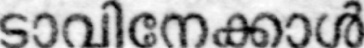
ടാവിനേക്കാള്‍
